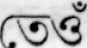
তেওঁ
